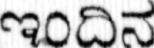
ಇಂದಿನ
